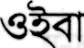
ওইবা
